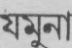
যমুনা
